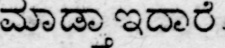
ಮಾಡ್ತಾಇದಾರೆ.
